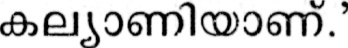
കല്യാണിയാണ്.’
